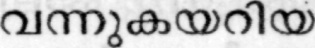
വന്നുകയറിയ
